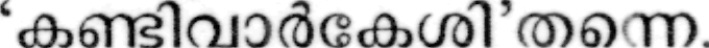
'കണ്ടിവാര്‍കേശി'തന്നെ.
